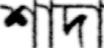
শাদা
